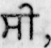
ਸੀ,
